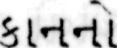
કાનનો
